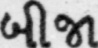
બીજા
